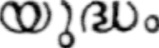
യുദ്ധം
